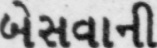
બેસવાની
